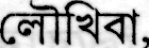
লৌখিবা,
